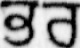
ਭਰ
